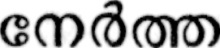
നേര്‍ത്ത
